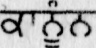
ਕਾਨੂੰਨ
